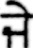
ਜੇ
